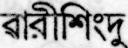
ৱারীশিংদু
